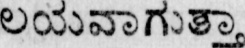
ಲಯವಾಗುತ್ತಾ
